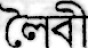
লৈবী
